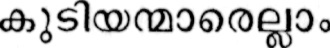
കുടിയന്മാരെല്ലാം
